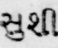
સુશી
